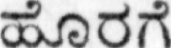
ಹೊರಗೆ
